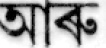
আৰু
